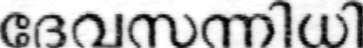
ദേവസന്നിധി
